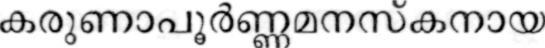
കരുണാപൂര്‍ണ്ണമനസ്കനായ
